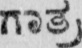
ಗಾತ್ರ
